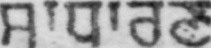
ਸਾਧਾਰਣ
